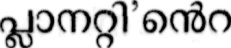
പ്ലാനറ്റി'ന്റെ
